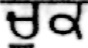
ਚੁਕ
